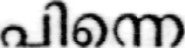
പിന്നെ
